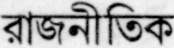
রাজনীতিক
